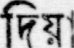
দিয়া
